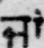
ਜਾਂ
